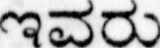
ಇವರು
